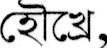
হৌখ্রে,
